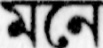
মনে
